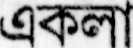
একলা
